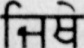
ਜਿਥੇ
